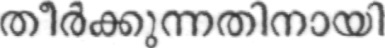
തീര്‍ക്കുന്നതിനായി
